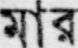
মার
